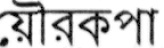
য়ৌরকপা
